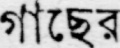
গাছের
